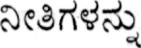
ನೀತಿಗಳನ್ನು
